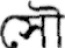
সৌ
